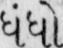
ધંધો
